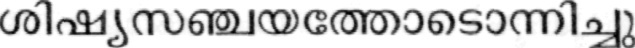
ശിഷ്യസഞ്ചയത്തോടൊന്നിച്ചു
